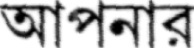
আপনার
